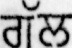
ਗੱਲ
